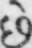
છે
